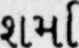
શર્મા
